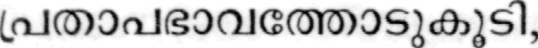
പ്രതാപഭാവത്തോടുകൂടി,
